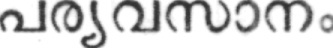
പര്യവസാനം
